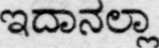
ಇದಾನಲ್ಲಾ
